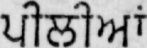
ਪੀਲੀਆਂ
